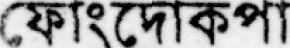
ফোংদোকপা
